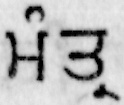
ਮੰਤ੍ਰ,
